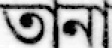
তানা
